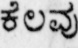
ಕೆಲವು
